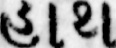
હાથ
